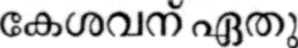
കേശവന്ഏതു
